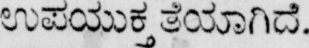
ಉಪಯುಕ್ತತೆಯಾಗಿದೆ.
